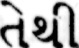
તેથી
